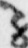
કે
